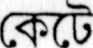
কেটে
